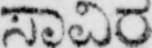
ಸಾವಿರ
